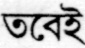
তবেই
